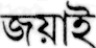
জয়াই
